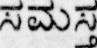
ಸಮಸ್ತ
